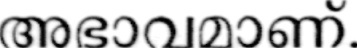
അഭാവമാണ്.
